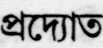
প্রদ্যোত
